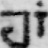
ਹਾਂ
